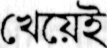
খেয়েই
